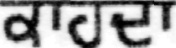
ਕਾਹਦਾ
